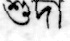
শুদা
